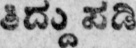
ತಿದ್ದುಪಡಿ
